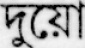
দুয়ো
